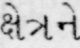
ક્ષેત્રને
